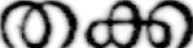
തക്ക
